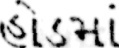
હોડમાં
